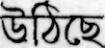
উঠিছে
